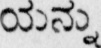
ಯನ್ನು
